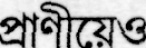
প্রাণীয়েও
